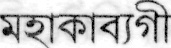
মহাকাব্যগী
